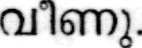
വീണു.
